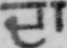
ਦਾ
